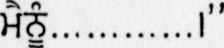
ਮੈਨੂੰ............।''
